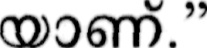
യാണ്.”
